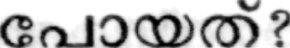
പോയത്?
